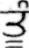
ਤੂੰ
